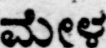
ಮೇಳ
